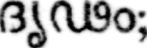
ദൃഢം;
